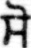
ਸੋ
